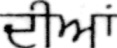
ਦੀਆਂ
